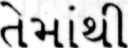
તેમાંથી
